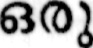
ഒരു
